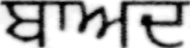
ਬਾਅਦ
